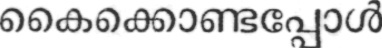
കൈക്കൊണ്ടപ്പോള്‍
